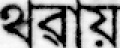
থৱায়
